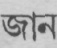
জান
